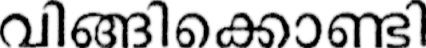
വിങ്ങിക്കൊണ്ടി
